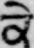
ਕੇ
